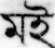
মই
